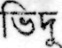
ভিদু
